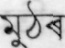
মুঠৰ
